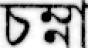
চম্না
